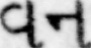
વન
